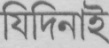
যিদিনাই
